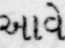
આવે
